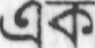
এক
